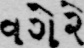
વગેરે
